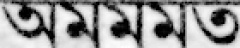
অমমমত
